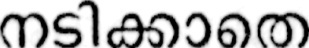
നടിക്കാതെ
